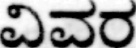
ವಿವರ
